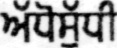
ਅੱਧੋਸੁੱਧੀ
